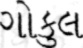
ગોકુલ
